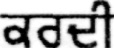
ਕਰਦੀ
